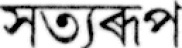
সত্যৰূপ
